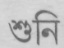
শুনি
